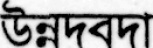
উন্নদবদা
